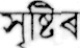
সৃষ্টিৰ
